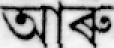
আৰু
